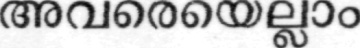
അവരെയെല്ലാം
